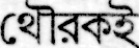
থৌরকই
